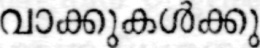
വാക്കുകള്‍ക്കു
